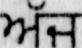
ਅੱਜ
